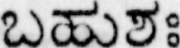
ಬಹುಶಃ
